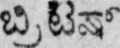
ಬ್ರಿಟಿಷ್
